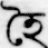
হৈ
